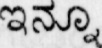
ಇನ್ನೂ
